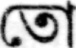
তো
